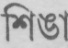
শিঙা
